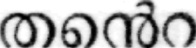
തന്റെ
